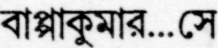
বাপ্পাকুমার...সে
